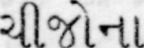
ચીજોના
